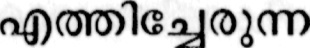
എത്തിച്ചേരുന്ന
